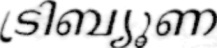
ട്രിബ്യൂണ
